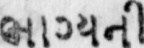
ભાગ્યની
